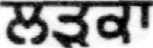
ਲੜਕਾ
